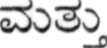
ಮತ್ತು
